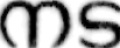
നട
